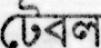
টেবল
